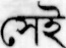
সেই
